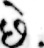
છે.
